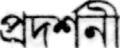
প্রদর্শনী
